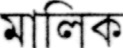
মালিক
